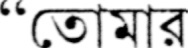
“তোমার
